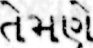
તેમણે
